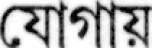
যোগায়
